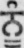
ਨੂੰ
